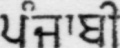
ਪੰਜਾਬੀ
